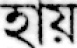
হায়
